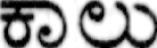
ಕಾಲು
